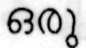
ഒരു
